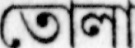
তোলা
